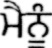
ਮੈਨੂੰ
